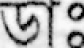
ডাঃ
